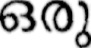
ഒരു
